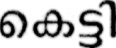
കെട്ടി
